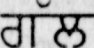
ਗੱਲ
